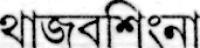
থাজবশিংনা
